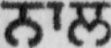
ਨਾਲ
